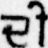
ਦੀ
